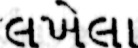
લખેલા
